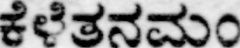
ಕೆಳೆತನಮಂ
